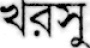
খরসু
